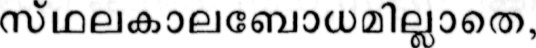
സ്ഥലകാലബോധമില്ലാതെ,
